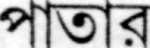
পাতার
